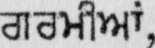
ਗਰਮੀਆਂ,
